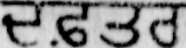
ਦਫ਼ਤਰ
